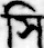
সি
